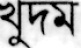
খুদম
